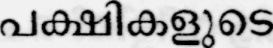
പക്ഷികളുടെ
